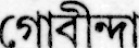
গোবীন্দা
